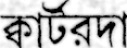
ক্বার্টরদা
